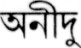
অনীদু
